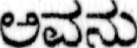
ಅವನು
